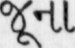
જૂના
